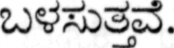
ಬಳಸುತ್ತವೆ.
